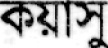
কয়াসু
